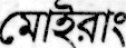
মোইরাং
